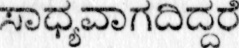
ಸಾಧ್ಯವಾಗದಿದ್ದರೆ
